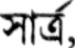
সার্ত্র,
